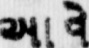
આવે
